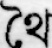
থৈ
